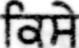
ਕਿਸੇ
